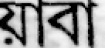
য়াবা
